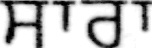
ਸਾਰਾ
